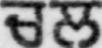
ਚਲ
